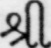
શ્રી
